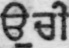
ਉਚੀ
